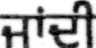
ਜਾਂਦੀ
